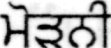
ਮੋੜਨੀ
